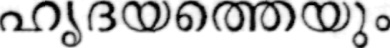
ഹൃദയത്തെയും
